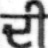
ਦੀ
